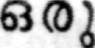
ഒരു
